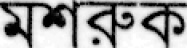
মশরুক
